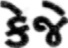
કેજે
